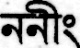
ননীং
